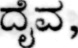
ದೈವ,
